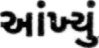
આંખ્યું
